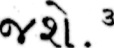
જશે.૩
